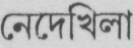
নেদেখিলা
